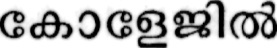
കോളേജില്‍
